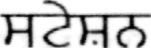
ਸਟੇਸ਼ਨ
